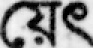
য়েৎ
